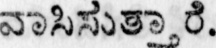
ವಾಸಿಸುತ್ತಾರೆ.
